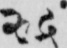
રુદ્રં
